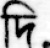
দি.
